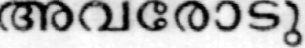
അവരോടു
